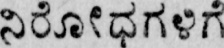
ನಿರೋಧಗಳಿಗೆ
